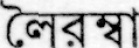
লৈরম্বা
